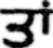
ਤਾਂ
